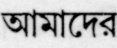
আমাদের
